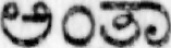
ಅಂತಾ
